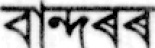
বান্দৰৰ
